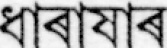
ধাৰাষাৰ
